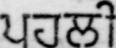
ਪਹਲੀ
